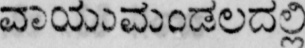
ವಾಯುಮಂಡಲದಲ್ಲಿ
